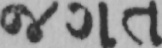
જગત
